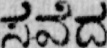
ಸವೆದ
